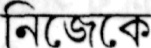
নিজেকে
